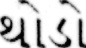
થોડો
